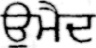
ਉਮੈਦ
